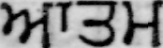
ਆਤਮ
